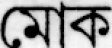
মোক
